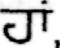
ਹਾਂ,
